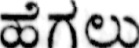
ಹೆಗಲು
